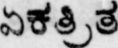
ಏಕತ್ರಿತ
